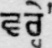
ਵਰ੍ਹੇ'
